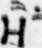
ਮੈਂ
